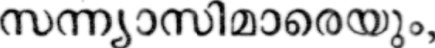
സന്ന്യാസിമാരെയും,
